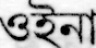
ওইনা
